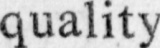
quality
